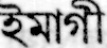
ইমাগী
